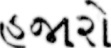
હજારો
